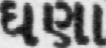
ઘણા
